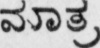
ಮಾತ್ರ
